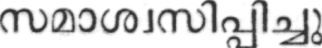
സമാശ്വസിപ്പിച്ചു
